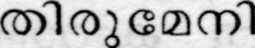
തിരുമേനി
